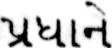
પ્રધાને
